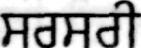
ਸਰਸਰੀ
